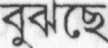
বুঝছে
